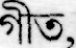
গীত,
